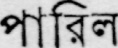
পারিল
